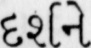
દર્શને
